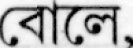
বোলে,
